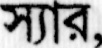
স্যার,
